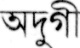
অদুগী
